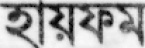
হায়ফম
